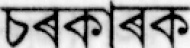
চৰকাৰক
